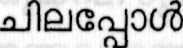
ചിലപ്പോള്‍
